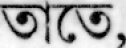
তাতে,
